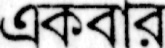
একবার
